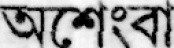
অশেংবা
